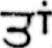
ਤਾਂ
